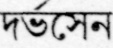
দর্ভসেন
